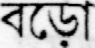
বড়ো
